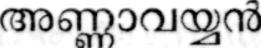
അണ്ണാവയ്യന്‍
